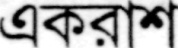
একরাশ
